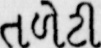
તળેટી
